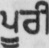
ਪੂਰੀ
